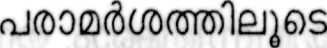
പരാമര്‍ശത്തിലൂടെ
